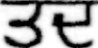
ਤਦ
